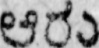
ಆರು
